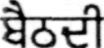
ਬੈਠਦੀ
